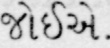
જોઈએ.
